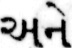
અને
